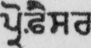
ਪ੍ਰੋਫ਼ੈਸਰ
